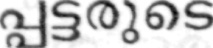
പ്പട്ടരുടെ
